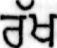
ਰੱਖ
